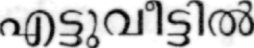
എട്ടുവീട്ടില്‍
